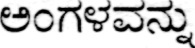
ಅಂಗಳವನ್ನು
